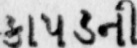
કાપડની
